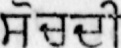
ਸੋਚਦੀ
